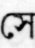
সে
